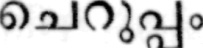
ചെറുപ്പം
